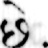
છે.
